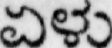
ಏಳು
